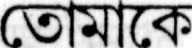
তোমাকে
